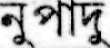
নুপাদু
